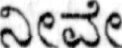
ನೀವೇ
